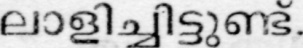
ലാളിച്ചിട്ടുണ്ട്.
